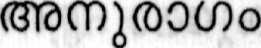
അനുരാഗം
